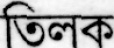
তিলক
